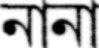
নানা
